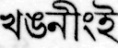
খঙনীংই
